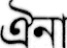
ঐনা
